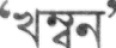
‘খম্বন’
